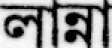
লান্না
